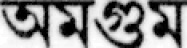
অমগুম
